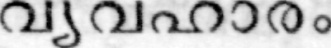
വ്യവഹാരം
